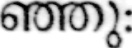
ഞ്ഞു:
